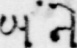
બંને
